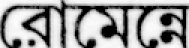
রোমেন্নে
